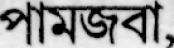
পামজবা,
